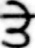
ਤੇ
